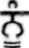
ਨੂੰ
